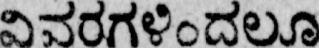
ವಿವರಗಳಿಂದಲೂ
